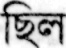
ছিল
